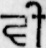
ਵੀ
